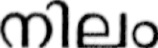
നിലം
